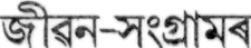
জীৱন-সংগ্ৰামৰ
